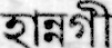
হান্নগী
